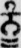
ਨੂੰ
